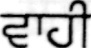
ਵਾਹੀ
